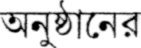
অনুষ্ঠানের
